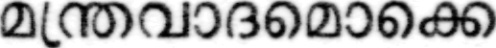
മന്ത്രവാദമൊക്കെ
